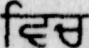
ਵਿਚ
